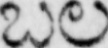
ಬಲ
